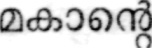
മകാന്റെ
